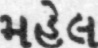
મહેલ
